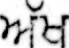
ਅੱਖ
